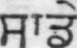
ਸਾਡੇ
